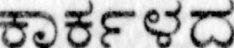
ಕಾರ್ಕಳದ
